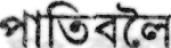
পাতিবলৈ
